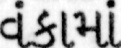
વંકામાં
